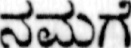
ನಮಗೆ
